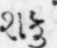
શકું
